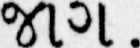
જાગ.
